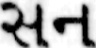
સન
